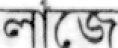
লাজে
